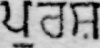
ਪੁਰਸ਼
